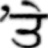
'ਤੇ
